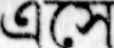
এসে
